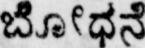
ಬೋಧನೆ
